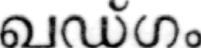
ഖഡ്ഗം
